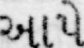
આપે
